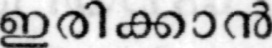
ഇരിക്കാന്‍
